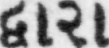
દ્વારા
